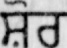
ਸ਼ੋਰ
